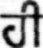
ਹੀ
